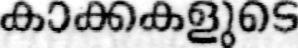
കാക്കകളുടെ
